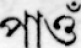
পাওঁ
